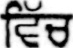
ਵਿੱਚ
